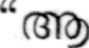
"ആ
